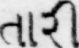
તારી
